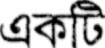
একটি
